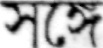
সঙ্গে
